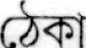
ঠেকা
